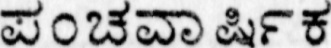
ಪಂಚವಾರ್ಷಿಕ
